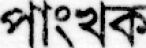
পাংখক
